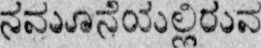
ನಮೂನೆಯಲ್ಲಿರುವ
